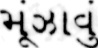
મૂંઝાવું
